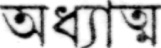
অধ্যাত্ম
